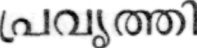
പ്രവൃത്തി
